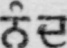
ਨੰਦ
